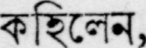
কহিলেন,
